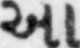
આ
